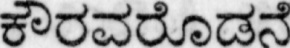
ಕೌರವರೊಡನೆ
